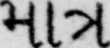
માત્ર
